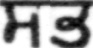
ਸਭ
